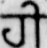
ਹੀ
